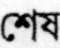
শেষ
